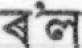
ৰ'ল
